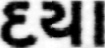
દયા
